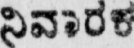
ನಿವಾರಕ
